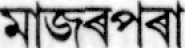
মাজৰপৰা
